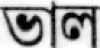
ভাল
